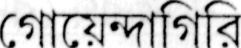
গোয়েন্দাগিরি
